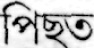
পিছত
